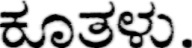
ಕೂತಳು.
